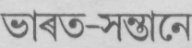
ভাৰত-সন্তানে
